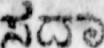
ಸದಾ
